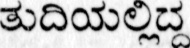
ತುದಿಯಲ್ಲಿದ್ದ
